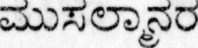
ಮುಸಲ್ಮಾನರ
